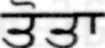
ਤੋਤਾ
